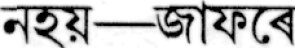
নহয়-জাফৰে
